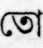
তো
